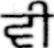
ਵੀ
